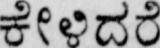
ಕೇಳಿದರೆ
